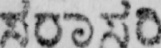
ಸರಾಸರಿ
